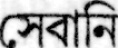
সেবানি
